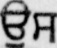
ਉਸ
